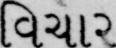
વિચાર
